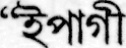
“ইপাগী
